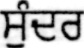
ਸੁੰਦਰ
